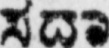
ಸದಾ
